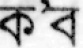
ক'ব
